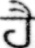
ਹੈ
